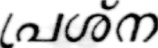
പ്രശ്ന
